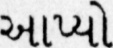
આપ્યો
